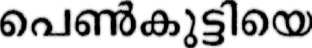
പെണ്‍കുട്ടിയെ
